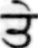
ਤੇ
